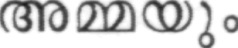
അമ്മയും
